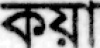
কয়া
